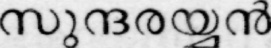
സുന്ദരയ്യന്‍
